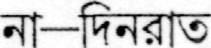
না—দিনরাত
